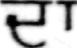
ਦਾ
